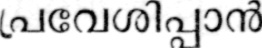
പ്രവേശിപ്പാന്‍
